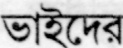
ভাইদের
